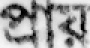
প্ৰায়
